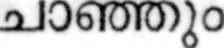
ചാഞ്ഞും
